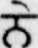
ਨੇ
